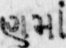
ણમાં
